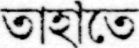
তাহাতে
